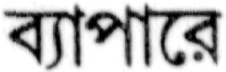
ব্যাপারে
